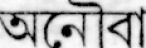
অনৌবা
